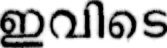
ഇവിടെ
